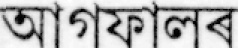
আগফালৰ
